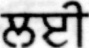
ਲਈ
